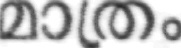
മാത്രം
